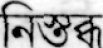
নিস্তব্ধ
